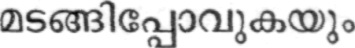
മടങ്ങിപ്പോവുകയും
